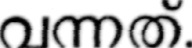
വന്നത്.
